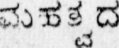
ಮಹತ್ವದ
